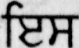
ਇਸ
